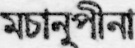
মচানুপীনা
